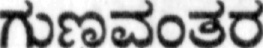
ಗುಣವಂತರ
